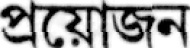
প্রয়োজন
